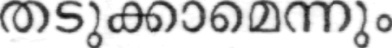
തടുക്കാമെന്നും
